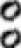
ঃ
